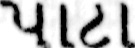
પાટા
